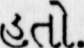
હતો.
